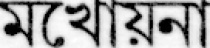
মখোয়না
